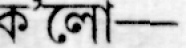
ক'লো-
